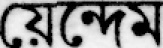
য়েন্দেম
